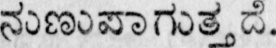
ನುಣುಪಾಗುತ್ತದೆ.
